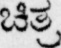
ಚಿತ್ರ
